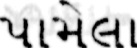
પામેલા
